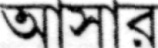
আসার
